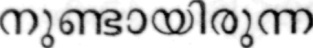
നുണ്ടായിരുന്ന
